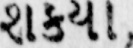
શક્યા,
